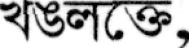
খঙলক্তে,
